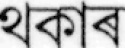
থকাৰ
